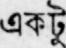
একটু
